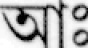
আঃ
